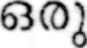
ഒരു
